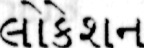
લોકેશન
